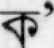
ক'
